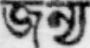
জন্য
